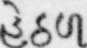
હેઠળ
